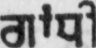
ਗਾਂਧੀ
